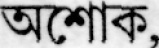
অশোক,
